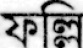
ফম্লি
